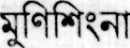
মুণিশিংনা
